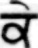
ਕੇ
